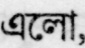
এলো,
